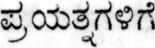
ಪ್ರಯತ್ನಗಳಿಗೆ
